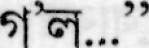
গ'ল..."
